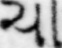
ચા
